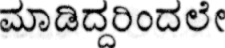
ಮಾಡಿದ್ದರಿಂದಲೇ
